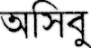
অসিবু
